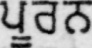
ਪੂਰਨ
